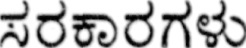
ಸರಕಾರಗಳು
